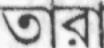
তারা
